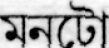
মনটো
